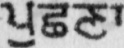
ਪੁਛਣਾ
